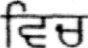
ਵਿਚ
